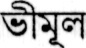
ভীমূল
